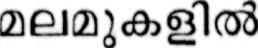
മലമുകളില്‍
